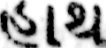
હાથ
